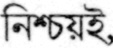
নিশ্চয়ই,
